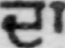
ਦਾ
